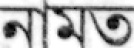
নামত
